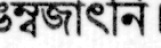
ঙম্বজাৎনি
